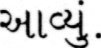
આવ્યું.
